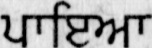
ਪਾਇਆ
